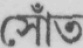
সোঁত
